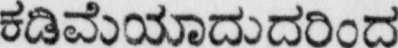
ಕಡಿಮೆಯಾದುದರಿಂದ
